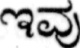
ಇವು
